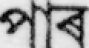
পাৰ
